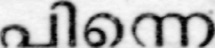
പിന്നെ
